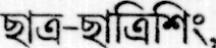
ছাত্র-ছাত্রিশিং,
